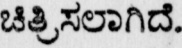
ಚಿತ್ರಿಸಲಾಗಿದೆ.
